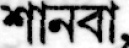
শানবা,
